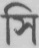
সি
